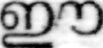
ഈ
